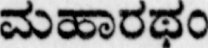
ಮಹಾರಥಂ
